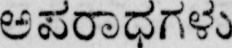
ಅಪರಾಧಗಳು
